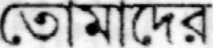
তোমাদের
